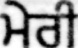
ਮੇਰੀ
